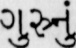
ગુરુનું
